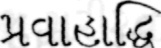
પ્રવાહાદ્ધિ
